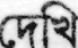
দেখি
